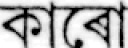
কাৰো
